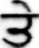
ਤੇ
